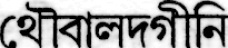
থৌবালদগীনি
